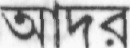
আদর
